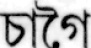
চাগৈ
